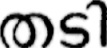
തടി
